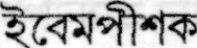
ইবেমপীশক
